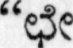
“ಛೇ
